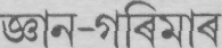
জ্ঞান-গৰিমাৰ
